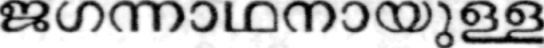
ജഗന്നാഥനായുള്ള
